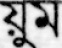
য়ুম
